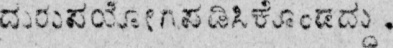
ದುರುಪಯೋಗಪಡಿಸಿಕೊಂಡದ್ದು.
